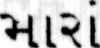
મારાં
